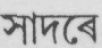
সাদৰে
